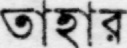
তাহার
